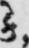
કે,
